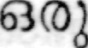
ഒരു
